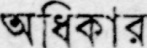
অধিকার
